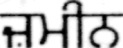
ਜ਼ਮੀਨ
